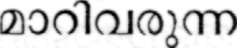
മാറിവരുന്ന
